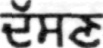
ਦੱਸਣ
